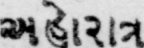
અહોરાત્ર
